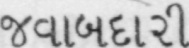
જવાબદારી
